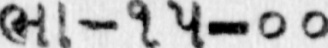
ભા-૧૫-૦૦
